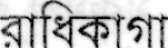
রাধিকাগা
